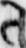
તે
